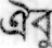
ঐবু
